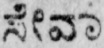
ಸೇವಾ
